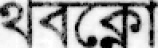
থবক্নো
